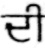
ਦੀ
